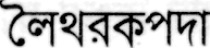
লৈথরকপদা
